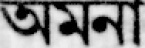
অমনা
